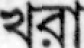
খরা
